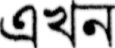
এখন
